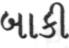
બાકી
